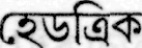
হেডত্রিক
